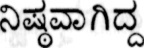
ನಿಷ್ಠವಾಗಿದ್ದ
